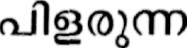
പിളരുന്ന
